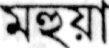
মহুয়া
